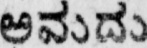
ಆಮದು
